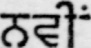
ਨਵੀਂ
